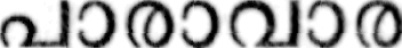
പാരാവാര
